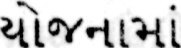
યોજનામાં
